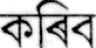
কৰিব
